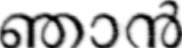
ഞാന്‍
